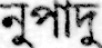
নুপাদু
